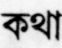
কথা
